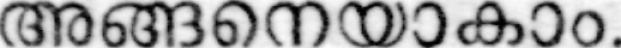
അങ്ങനെയാകാം.
